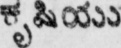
ಕೃಷಿಯು
